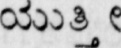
ಯುತ್ತೀ
